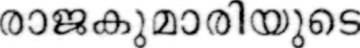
രാജകുമാരിയുടെ
